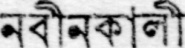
নবীনকালী
